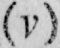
(v)
